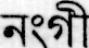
নংগী
